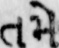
તમે
